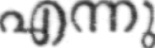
എന്നു
